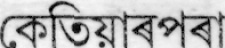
কেতিয়াৰপৰা
